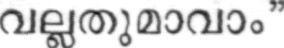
വല്ലതുമാവാം”
